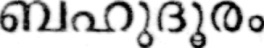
ബഹുദൂരം
